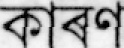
কাৰণ
